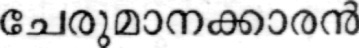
ചേരുമാനക്കാരന്‍
